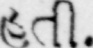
હતી.
